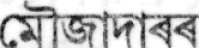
মৌজাদাৰৰ
